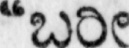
“ಬರೀ
